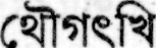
থৌগৎখি
